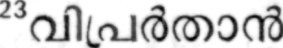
23വിപ്രര്‍താന്‍
